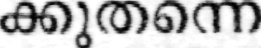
ക്കുതന്നെ
